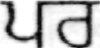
ਪਰ
